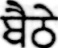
ਬੈਠੇ
